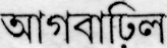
আগবাঢ়িল
